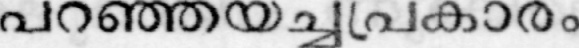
പറഞ്ഞയച്ചപ്രകാരം
